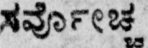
ಸರ್ವೋಚ್ಚ
